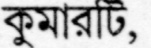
কুমারটি,
